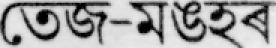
তেজ-মঙহৰ
